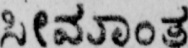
ಸೀಮಾಂತ
